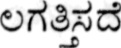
ಲಗತ್ತಿಸದೆ
